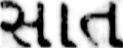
સાત
